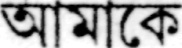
আমাকে
